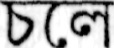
চলে
